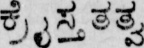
ಕ್ರೈಸ್ತತತ್ವ
